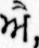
ਐ,
